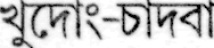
খুদোং-চাদবা
